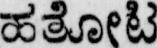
ಹತೋಟಿ
